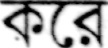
করে
